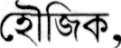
হৌজিক,
